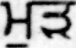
ਮੁੜ
